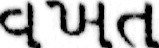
વખત
